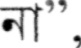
না”,
